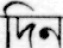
দিন
